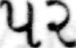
પર
